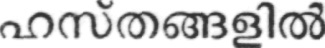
ഹസ്തങ്ങളില്‍
